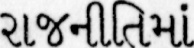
રાજનીતિમાં
